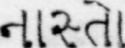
નાસ્તો
